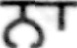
ਨਾ
